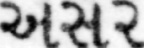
અસર
